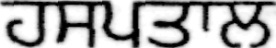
ਹਸਪਤਾਲ
